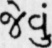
જેવું
